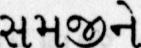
સમજીને
